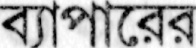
ব্যাপারের
